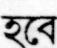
হবে
